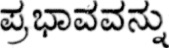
ಪ್ರಭಾವವನ್ನು
